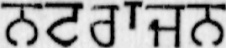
ਨਟਰਾਜਨ
